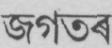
জগতৰ
